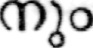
നും
